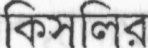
কিসলির
